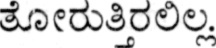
ತೋರುತ್ತಿರಲಿಲ್ಲ.
